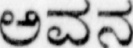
ಅವನ
